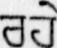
ਰਹੇ
